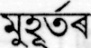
মুহূর্তৰ
